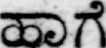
ಹಾಗೆ
